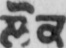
ਲੋਕ
